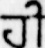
ਹੀ
